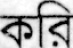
করি
